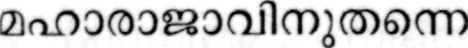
മഹാരാജാവിനുതന്നെ
